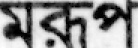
মরূপ
